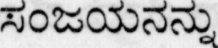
ಸಂಜಯನನ್ನು
